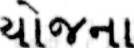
યોજના
